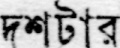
দশটার
